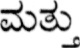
ಮತ್ತು
